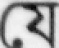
যে
